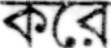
করে
